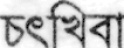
চৎখিবা
